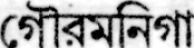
গৌরমনিনা
